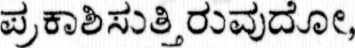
ಪ್ರಕಾಶಿಸುತ್ತಿರುವುದೋ,
